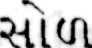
સોળ
